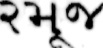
રમૂજ
